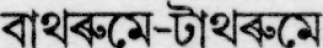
বাথৰুমে-টাথৰুমে
